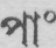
পা
